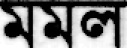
মমল
